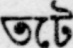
তটে
